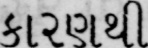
કારણથી
